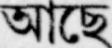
আছে
